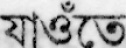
যাওঁতে
